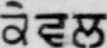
ਕੇਵਲ
